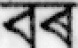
বৰ
